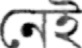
নেই
